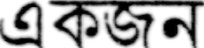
একজন
